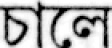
চালে
